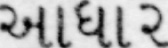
આધાર
